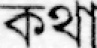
কথা
